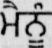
ਮੈਨੂੰ
